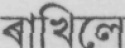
ৰাখিলে
